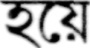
হয়ে
